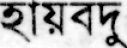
হায়বদু
